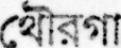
থৌরগা
